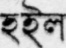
হইল
